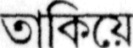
তাকিয়ে
